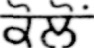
ਕੋਲੋਂ
